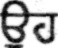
ਉਹ
